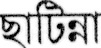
ছাটিন্না
